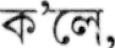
ক'লে,
